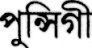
পুন্সিগী
